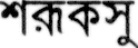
শরূকসু
